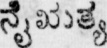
ನೈಋತ್ಯ
